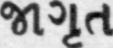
જાગૃત
